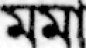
মমা
